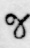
જ
